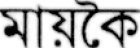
মায়কৈ
